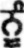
ਨੂੰ
